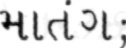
માતંગ;
